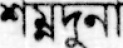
শম্নদুনা
